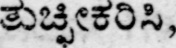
ತುಚ್ಛೀಕರಿಸಿ,
